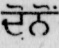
ਦੋਨੋਂ
